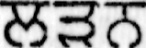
ਲੜਨ
